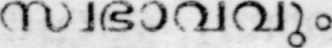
സ്വഭാവവും
